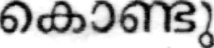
കൊണ്ടു
